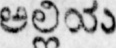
ಅಲ್ಲಿಯ
